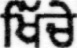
ਖਿੱਚੇ
